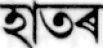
হাতৰ
